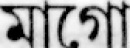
মাগো
